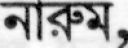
নারুম,
